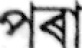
পৰা
